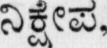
ನಿಕ್ಷೇಪ,
